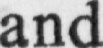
and
